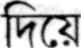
দিয়ে
